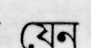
যেন
